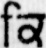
ਕਿ
